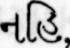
નહિ,
